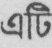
এটি
